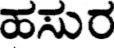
ಹಸುರ
